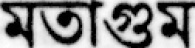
মতাগুম
